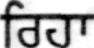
ਰਿਹਾ
